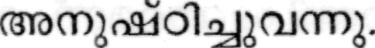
അനുഷ്ഠിച്ചുവന്നു.
